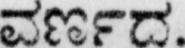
ವರ್ಣದ.
